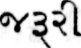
જરૂરી
